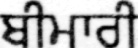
ਬੀਮਾਰੀ
